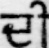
ਦੀ
